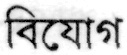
বিযোগ
